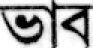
ভাব
